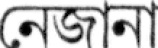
নেজানা
